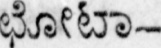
ಛೋಟಾ-
